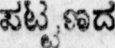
ಪಟ್ಟಣದ
